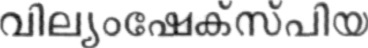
വില്യംഷേക്സ്പിയ
